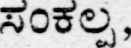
ಸಂಕಲ್ಪ,
